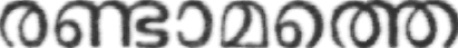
രണ്ടാമത്തെ
